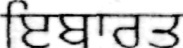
ਇਬਾਰਤ
